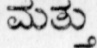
ಮತ್ತು
